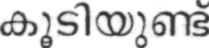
കൂടിയുണ്ട്
